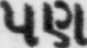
પણ
